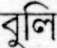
বুলি
